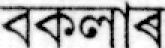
বকলাৰ
